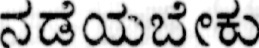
ನಡೆಯಬೇಕು
